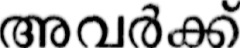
അവര്‍ക്ക്
